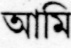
আমি
